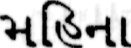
મહિના
